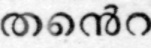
തന്റെ
